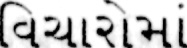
વિચારોમાં
